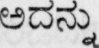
ಅದನ್ನು
